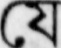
যে
